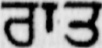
ਰਾਤ
